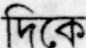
দিকে
